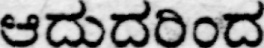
ಆದುದರಿಂದ
